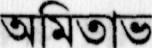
অমিতাভ
